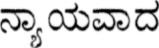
ನ್ಯಾಯವಾದ
